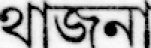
থাজনা
